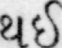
થઈ
